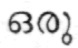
ഒരു
